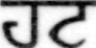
ਹਟ
